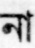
না
